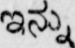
ಇನ್ನು
